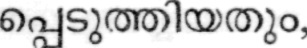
പ്പെടുത്തിയതും,
